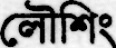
লৌশিং
